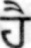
ਹੈ
